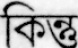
কিন্তু
